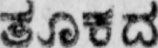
ತೂಕದ
